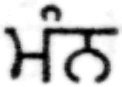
ਮੰਨ
